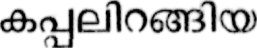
കപ്പലിറങ്ങിയ
